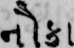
નૌકા
